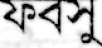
ফবসু
